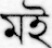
মই
